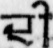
ਦੀ
